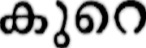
കുറെ
